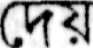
দেয়
